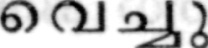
വെച്ചു
